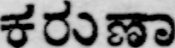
ಕರುಣಾ
